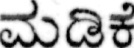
ಮಡಿಕೆ
